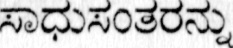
ಸಾಧುಸಂತರನ್ನು
